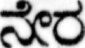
ನೇರ
